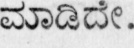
ಮಾಡಿದೇ.
